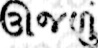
ઊજળું
